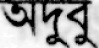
অদুবু
